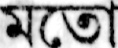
মতো
